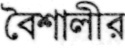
বৈশালীর
